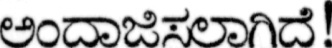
ಅಂದಾಜಿಸಲಾಗಿದೆ!
